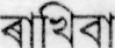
ৰাখিবা
